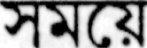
সময়ে
